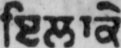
ਇਲਾਕੇ
